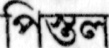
পিস্তল
